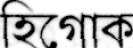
হিগোক
